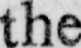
the
